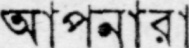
আপনারা
